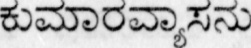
ಕುಮಾರವ್ಯಾಸನು
